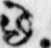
છે.
